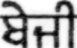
ਬੇਜੀ
